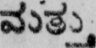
ಮತ್ತು
